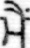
ਮੈਂ
